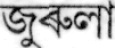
জুৰুলা
